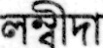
লম্বীদা
